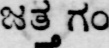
ಜತ್ತಗಂ
